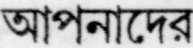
আপনাদের
